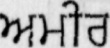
ਅਮੀਰ
